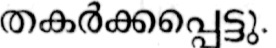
തകര്‍ക്കപ്പെട്ടു.
